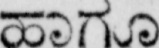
ಹಾಗೂ
